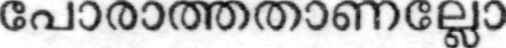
പോരാത്തതാണല്ലോ
